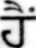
ਹੈਂ
